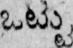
ಒಟ್ಟು
